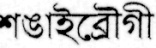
শঙাইব্লৌগী
